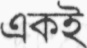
একই
